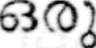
ഒരു
